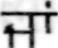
ਜਾਂ
